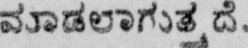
ಮಾಡಲಾಗುತ್ತದೆ.
